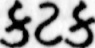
કટક
